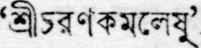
‘শ্রীচরণকমলেষু’
